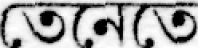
তেনেতে
